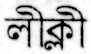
লীক্লী
